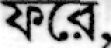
ফরে,
